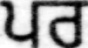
ਪਰ
